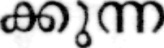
ക്കുന്ന
